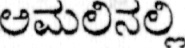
ಅಮಲಿನಲ್ಲಿ
